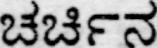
ಚರ್ಚಿನ
